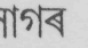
সাগৰ
